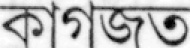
কাগজত
